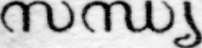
സന്ധ്യ
